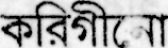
করিগীনো
